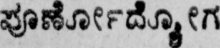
ಪೂರ್ಣೋದ್ಯೋಗ
